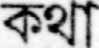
কথা
